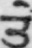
ਤੇ
